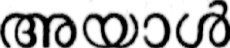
അയാള്‍
